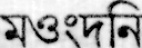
মওংদনি
